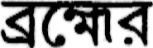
ব্রহ্মের
